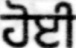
ਹੋਈ
